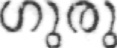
ഗുരു
